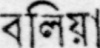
বলিয়া
